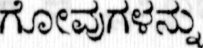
ಗೋವುಗಳನ್ನು
